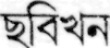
ছবিখন
